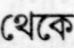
থেকে
